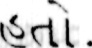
હતો.
